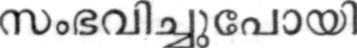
സംഭവിച്ചുപോയി
